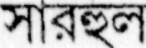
সারহুল
